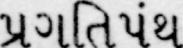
પ્રગતિપંથ
